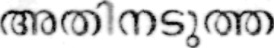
അതിനടുത്ത
